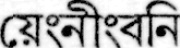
য়েংনীংবনি
